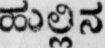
ಹುಲ್ಲಿನ
